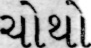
ચોથો
